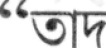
“তাদ
